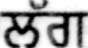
ਲੱਗ
